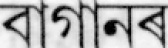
বাগানৰ
